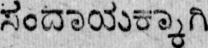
ಸಂದಾಯಕ್ಕಾಗಿ
